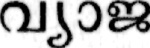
വ്യാജ
